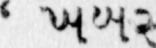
'ખબર
